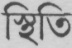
স্থিতি
